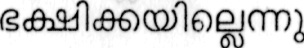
ഭക്ഷിക്കയില്ലെന്നു
